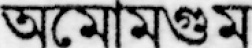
অমোমগুম
